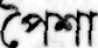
পৈশা
